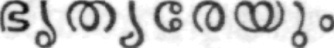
ഭൃത്യരേയും
